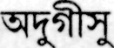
অদুগীসু
